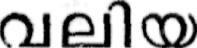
വലിയ
